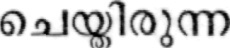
ചെയ്തിരുന്ന
